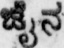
ಜೈನ
